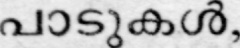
പാടുകള്‍,
